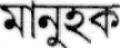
মানুহক
